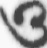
ও
